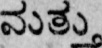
ಮತ್ತು
